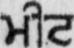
ਮੀਟ
